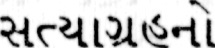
સત્યાગ્રહનો
